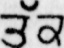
ਤੱਕ
